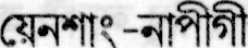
য়েনশাং-নাপীগী
